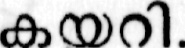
കയറി.
